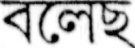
বলেছ
